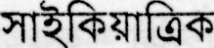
সাইকিয়াত্রিক
